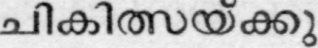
ചികിത്സയ്ക്കു
